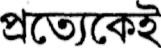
প্রত্যেকেই
